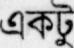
একটু
